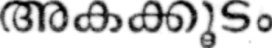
അകക്കൂടം
